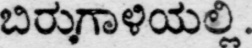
ಬಿರುಗಾಳಿಯಲ್ಲಿ.
